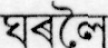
ঘৰলৈ
